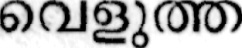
വെളുത്ത
